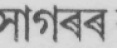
সাগৰৰ
